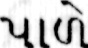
પાળે
